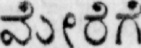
ಮೇರೆಗೆ
